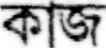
কাজ
